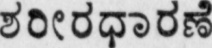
ಶರೀರಧಾರಣೆ
